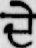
ਦੇ
